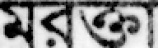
মরক্তা
